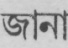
জানা
